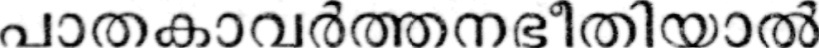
പാതകാവര്‍ത്തനഭീതിയാല്‍
